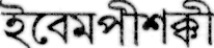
ইবেমপীশক্কী
